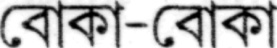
বোকা-বোকা
